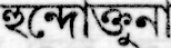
হুন্দোক্তুনা
